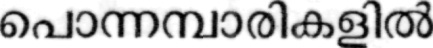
പൊന്നമ്പാരികളില്‍
